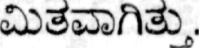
ಮಿತವಾಗಿತ್ತು.
